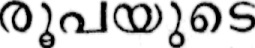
രൂപയുടെ
